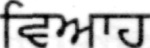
ਵਿਆਹ
